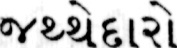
જથ્થેદારો
